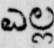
ಎಲ್ಲ
